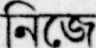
নিজে
